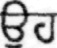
ਉਹ
